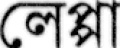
লেপ্পা
